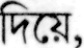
দিয়ে,
